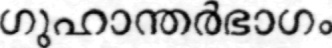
ഗുഹാന്തര്‍ഭാഗം
